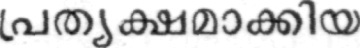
പ്രത്യക്ഷമാക്കിയ
